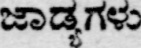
ಜಾಡ್ಯಗಳು
